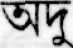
অদু
